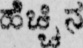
ಹೆಚ್ಚಿನ
